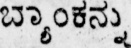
ಬ್ಯಾಂಕನ್ನು
